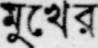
মুখের
